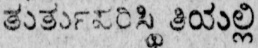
ತುರ್ತುಪರಿಸ್ಥಿತಿಯಲ್ಲಿ
